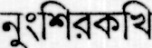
নুংশিরকখি
